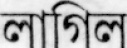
লাগিল
